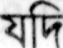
যদি
